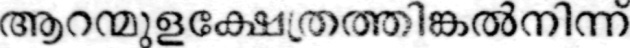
ആറന്മുളക്ഷേത്രത്തിങ്കല്‍നിന്ന്
